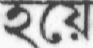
হয়ে
